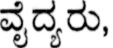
ವೈದ್ಯರು,
